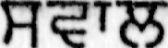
ਸਵਾਲ
